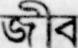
জীব
